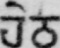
ਹੇਠ
